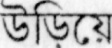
উড়িয়ে
